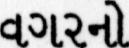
વગરનો
